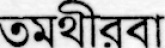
তমথীরবা
